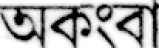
অকংবা
